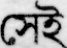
সেই
